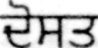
ਦੋਸਤ
